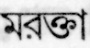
মরক্তা
